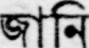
জানি
